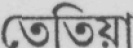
তেতিয়া
